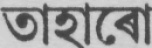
তাহাৰো
